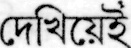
দেখিয়েই
